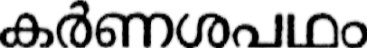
കര്‍ണശപഥം
